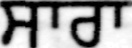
ਸਾਰਾ
